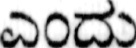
ಎಂದು
